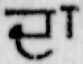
ਦਾ
